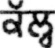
ਕੱਲ੍ਹ
